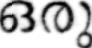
ഒരു
